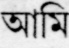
আমি
